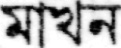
মাখন
